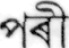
পৰী
